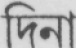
দিনা
